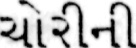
ચોરીની
